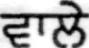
ਵਾਲੇ
